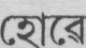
হোৱে
